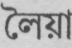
লৈয়া
